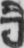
ਹੈ
